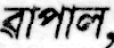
ৱাপাল,
